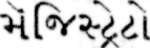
મૅજિસ્ટ્રેટો
